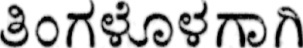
ತಿಂಗಳೊಳಗಾಗಿ
